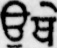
ਉਥੇ
